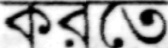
করতে
